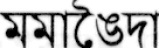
মমাঙৈদা
